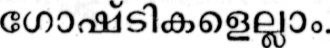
ഗോഷ്ടികളെല്ലാം.
